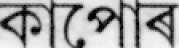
কাপোৰ
